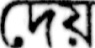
দেয়
